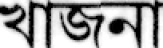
খাজনা
